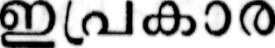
ഇപ്രകാര
